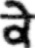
ਕੇ
